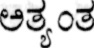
ಅತ್ಯಂತ
